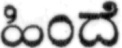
ಹಿಂದೆ
